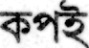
কপই
